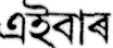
এইবাৰ
